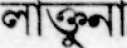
লাক্তুনা
